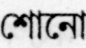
শোনো
